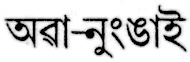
অৱা-নুংঙাই
